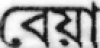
বেয়া
